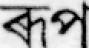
ৰূপ
